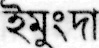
ইমুংদা
